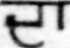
ਦਾ
